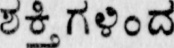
ಶಕ್ತಿಗಳಿಂದ
